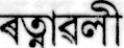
ৰত্নাৱলী
